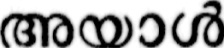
അയാള്‍
